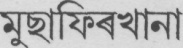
মুছাফিৰখানা
